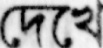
দেখে
